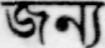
জন্য
